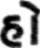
હો
